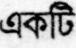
একটি
